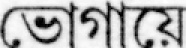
ভোগায়ে
